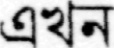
এখন
